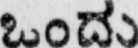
ಒಂದು
